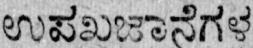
ಉಪಖಜಾನೆಗಳ
